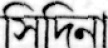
সিদিনা
